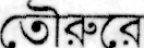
তৌরুরে
